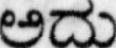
ಅದು
